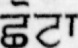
ਛੋਟਾ
